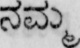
ನಮ್ಮ
